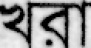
খরা
